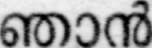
ഞാന്‍
